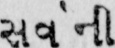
સર્વની
